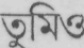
তুমিও
